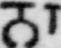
ਨਾ
